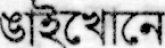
ঙাইখোনে
